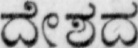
ದೇಶದ
